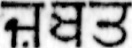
ਜ਼ਬਤ
